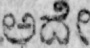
ಅದೇ
